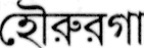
হৌরুরগা
